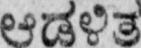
ಆಡಳಿತ
